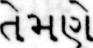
તેમણે
